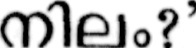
നിലം?’
